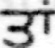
ਤਾਂ
